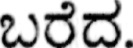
ಬರೆದ.
